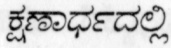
ಕ್ಷಣಾರ್ಧದಲ್ಲಿ
